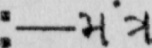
:-મંત્ર
